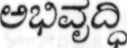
ಅಭಿವೃದ್ಧಿ
